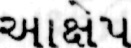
આક્ષેપ
